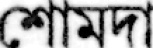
শোমদা
